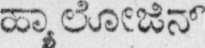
ಹ್ಯಾಲೋಜಿನ್
